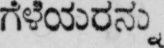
ಗೆಳೆಯರನ್ನು
